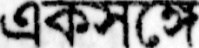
একসঙ্গে
